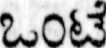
ಒಂಟೆ
